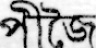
পীজৈ
